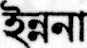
ইন্ননা
